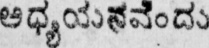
ಅಧ್ಯಯನವೆಂದು
